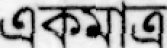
একমাত্র
